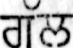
ਗੱਲ
